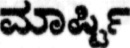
ಮಾಷ್ಟಿ೯
